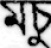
মচু
